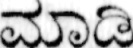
ಮಾಡಿ
